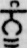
ਨੂੰ
